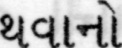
થવાનો
